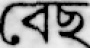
বেছ
